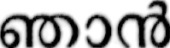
ഞാന്‍
